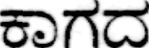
ಕಾಗದ
